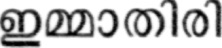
ഇമ്മാതിരി
